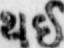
થઈ
